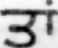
ਤਾਂ
